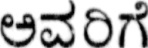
ಅವರಿಗೆ
